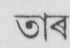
তাৰ
